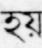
হয়
